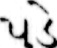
પડે
